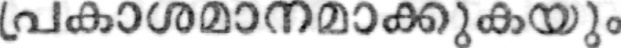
പ്രകാശമാനമാക്കുകയും
